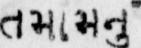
તમામનું
